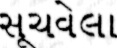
સૂચવેલા
